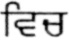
ਵਿਚ
